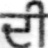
ਦੀ
